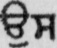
ਉਸ
